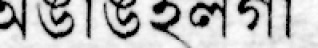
অঙাঙহলগা
